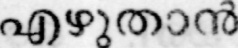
എഴുതാന്‍
